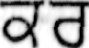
ਕਰ
